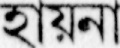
হায়না
